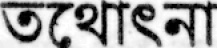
তথোৎনা
